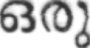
ഒരു
